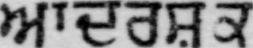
ਆਦਰਸ਼ਕ
